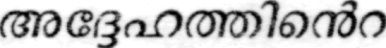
അദ്ദേഹത്തിന്റെ
